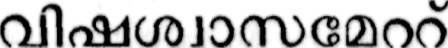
വിഷശ്വാസമേററ്
